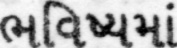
ભવિષ્યમાં
